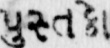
પુસ્તકો
